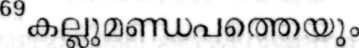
69കല്ലുമണ്ഡപത്തെയും
